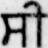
ਸੀ
